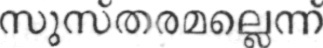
സുസ്തരമല്ലെന്ന്
